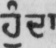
ਹੁੰਦਾ
